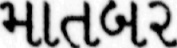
માતબર
